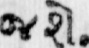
જશે.
